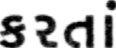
કરતાં
